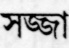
সজ্জা
